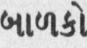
બાળકો
